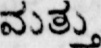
ಮತ್ತು
